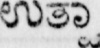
ಉತ್ಪಾ
